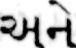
અને
